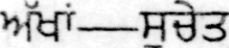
ਅੱਖਾਂ-ਸੁਚੇਤ
